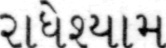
રાધેશ્યામ
